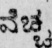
ವೆಚ್ಚ
